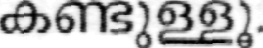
കണ്ടുള്ളൂ.
